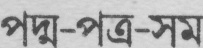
পদ্ম-পত্ৰ-সম
